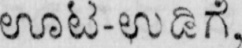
ಊಟ-ಉಡಿಗೆ,
